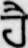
ਹੈ
